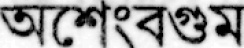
অশেংবগুম
